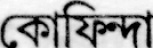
কোফিন্দা
